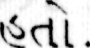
હતો.
